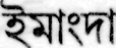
ইমাংদা
